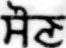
ਸੌਣ
